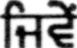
ਜਿਵੇਂ
